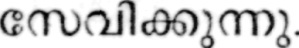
സേവിക്കുന്നു.
